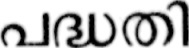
പദ്ധതി
